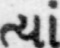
ત્યાં
